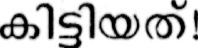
കിട്ടിയത്!
